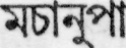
মচানুপা
